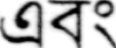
এবং
